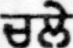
ਚਲੇ
